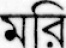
মরি
